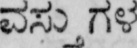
ವಸ್ತುಗಳ
